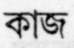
কাজ
